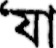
'যা
